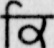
ਕਿ
